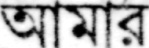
আমার
